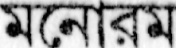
মনোরম
